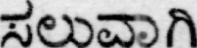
ಸಲುವಾಗಿ
